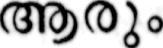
ആരും
